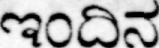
ಇಂದಿನ
